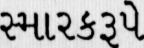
સ્મારકરૂપે
